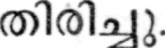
തിരിച്ചു.
